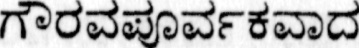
ಗೌರವಪೂರ್ವಕವಾದ
